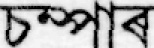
চম্পাৰ
